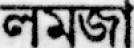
লমজা
